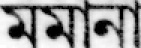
মমানা
